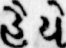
હૈયે
